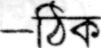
-ঠিক
